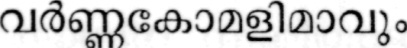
വര്‍ണ്ണകോമളിമാവും
